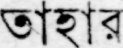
তাহার
